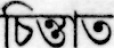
চিন্তাত
